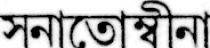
সনাতোম্বীনা
